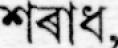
শৰাধ,
